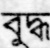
বুদ্ধ
